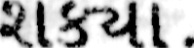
શક્યા.
